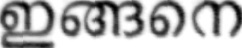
ഇങ്ങനെ
